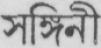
সঙ্গিনী
